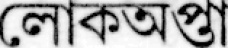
লোকঅপ্তা
